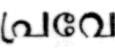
പ്രവേ
